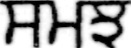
ਸਮਝ
